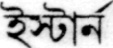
ইস্টার্ন
